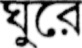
ঘুরে
